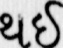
થઈ
